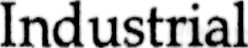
Industrial
